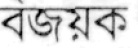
বিজয়ক
